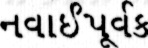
નવાઈપૂર્વક
